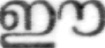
ഈ
